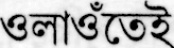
ওলাওঁতেই
